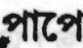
পাপে
